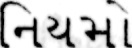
નિયમો
